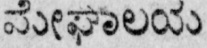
ಮೇಘಾಲಯ
